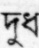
দুধ
